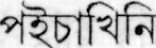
পইচাখিনি
